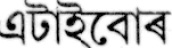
এটাইবোৰ
